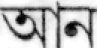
আন
